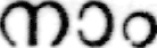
നാം
